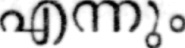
എന്നും
